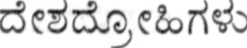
ದೇಶದ್ರೋಹಿಗಳು
